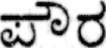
ಪೌರ
